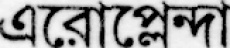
এরোপ্লেন্দা
